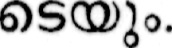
ടെയും.
